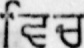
ਵਿਚ
